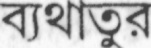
ব্যথাতুর
